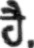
ਹੈ,
